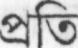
প্রতি
